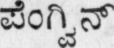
ಪೆಂಗ್ವಿನ್
